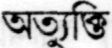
অত্যুক্তি
